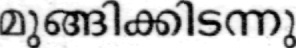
മുങ്ങിക്കിടന്നു
